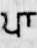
ਪਾ
